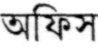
অফিস
